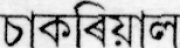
চাকৰিয়াল
